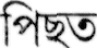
পিছত
